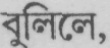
বুলিলে,
